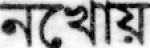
নখোয়
